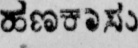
ಹಣಕಾಸು
